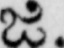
ಜಿ.
